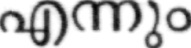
എന്നും
